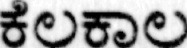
ಕೆಲಕಾಲ
